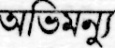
অভিমন্যু
